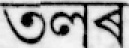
তলৰ
